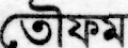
তৌফম
